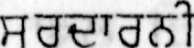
ਸਰਦਾਰਨੀ
